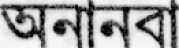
অনানবা
